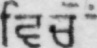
ਵਿਚੋਂ
